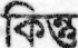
কিন্তু
